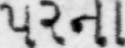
પરના
